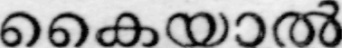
കൈയാല്‍
